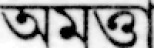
অমত্তা
